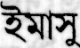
ইমাসু
